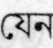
যেন
